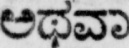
ಅಥವಾ
